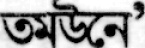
তমউনে’
